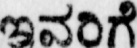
ಇವರಿಗೆ
